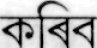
কৰিব
